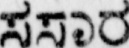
ಸಸಾರ
